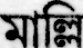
মাল্লি
